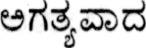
ಅಗತ್ಯವಾದ
